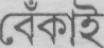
বেঁকাই
